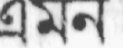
এমন
